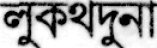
লুকথদুনা
